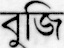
বুজি
